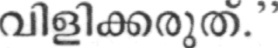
വിളിക്കരുത്."
